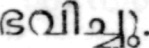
ഭവിച്ചു.
